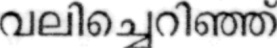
വലിച്ചെറിഞ്ഞ്
